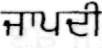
ਜਾਪਦੀ
